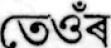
তেওঁৰ
